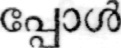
പ്പോള്‍
